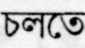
চলতে
